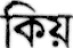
কিয়
